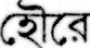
হৌরে
